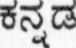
ಕನ್ನಡ
